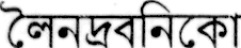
লৈনদ্রবনিকো
